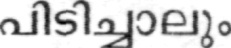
പിടിച്ചാലും
